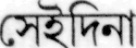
সেইদিনা
